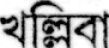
খল্লিবা
